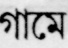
গামে
